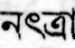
নৎত্রা
